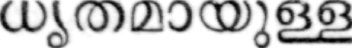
ധൃതമായുള്ള
